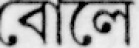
বোলে
